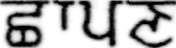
ਛਾਪਣ
